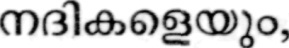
നദികളെയും,
